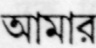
আমার
